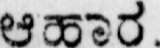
ಆಹಾರ.
